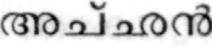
അച്ഛന്‍
